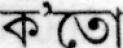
ক'তো
